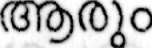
ആരും
